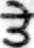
ਤੇ
